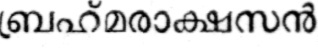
ബ്രഹ്മരാക്ഷസന്‍
